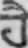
ਹੈ
